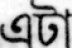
এটা
